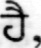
ਹੈ,
